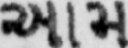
આમ
